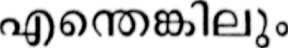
എന്തെങ്കിലും
